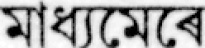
মাধ্যমেৰে
